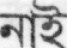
নাই
